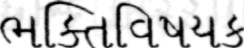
ભક્તિવિષયક
